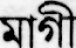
মাগী
